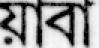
য়াবা
